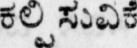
ಕಲ್ಪಿಸುವಿಕೆ
